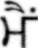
ਮੈਂ
